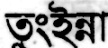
তুংইন্না
